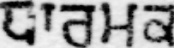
ਧਾਰਮਕ
